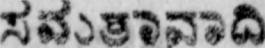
ಸಮತಾವಾದಿ
